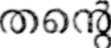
തന്റെ
